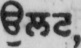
ਉਲਟ,
